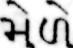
મેળે
